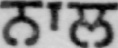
ਨਾਲ
